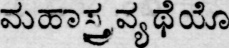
ಮಹಾಸ್ತ್ರವ್ಯಥೆಯೊ
